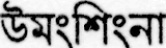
উমংশিংনা
